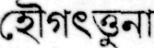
হৌগৎত্তুনা
